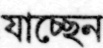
যাচ্ছেন
